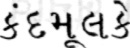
કંદમૂલકે
